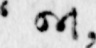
'જા,
